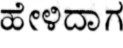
ಹೇಳಿದಾಗ
